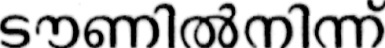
ടൌണില്‍നിന്ന്
